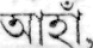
আহাঁ,
